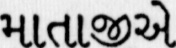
માતાજીએ
